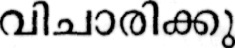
വിചാരിക്കു
